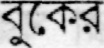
বুকের
